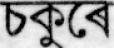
চকুৰে
